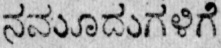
ನಮೂದುಗಳಿಗೆ
